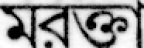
মরক্তা
